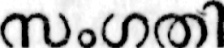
സംഗതി
